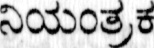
ನಿಯಂತ್ರಕ
